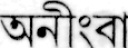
অনীংবা
